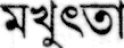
মখুৎতা
